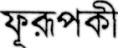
ফূরূপকী
